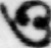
ও
